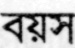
বয়স
